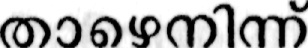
താഴെനിന്ന്
